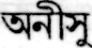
অনীসু
